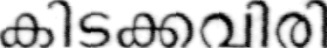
കിടക്കവിരി
